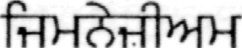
ਜਿਮਨੇਜ਼ੀਅਮ
